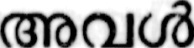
അവള്‍
